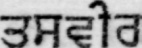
ਤਸਵੀਰ
